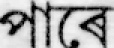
পাৰে
